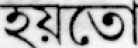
হয়তো
